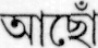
আছোঁ
